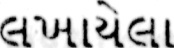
લખાયેલા
